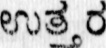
ಉತ್ತರ
